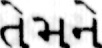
તેમને
